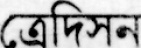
ত্রেদিসন
